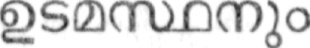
ഉടമസ്ഥനും
